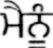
ਮੈਨੂੰ
